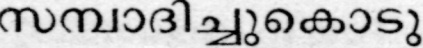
സമ്പാദിച്ചുകൊടു
